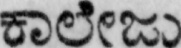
ಕಾಲೇಜು
